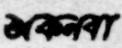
অকনবা
